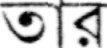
তার
